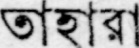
তাহারা
